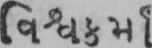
વિશ્વકર્મા.
